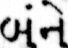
બંને
